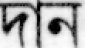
দান
